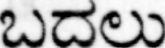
ಬದಲು
